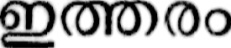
ഇത്തരം
